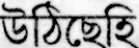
উঠিছেহি
